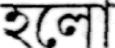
হলো
